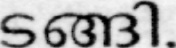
ടങ്ങി.
